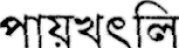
পায়খৎলি
